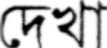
দেখা
